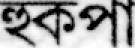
হুকপা
